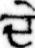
ਦੇ
